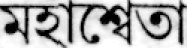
মহাশ্বেতা
